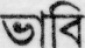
ভাবি
